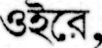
ওইরে,
